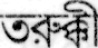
তরুক্কী
